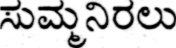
ಸುಮ್ಮನಿರಲು
